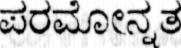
ಪರಮೋನ್ನತ
